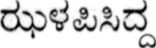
ಝಳಪಿಸಿದ್ದ
